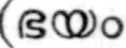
(ഭയം
